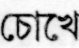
চোখে
